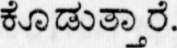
ಕೊಡುತ್ತಾರೆ.
